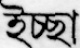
ইচ্ছা
